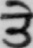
ਤੇ
